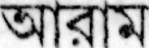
আরাম
